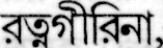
রত্নগীরিনা,
